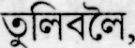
তুলিবলৈ,
